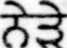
ਨੇੜੇ
